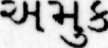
અમુક
